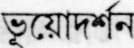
ভূয়োদর্শন
